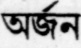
অর্জন
